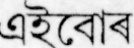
এইবোৰ
